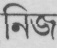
নিজ
